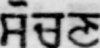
ਸੋਚਣ
